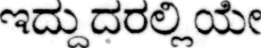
ಇದ್ದುದರಲ್ಲಿಯೇ
